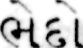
ભેદો
